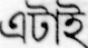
এটাই
